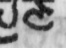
ਹੁਣ
